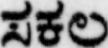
ಸಕಲ
